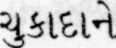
ચુકાદાને
